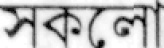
সকলো
